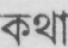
কথা
